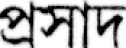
প্রসাদ
